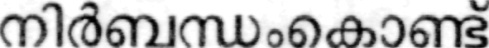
നിര്‍ബന്ധംകൊണ്ട്
